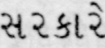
સરકારે
